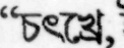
“চৎখ্রে,
